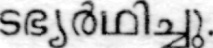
ടഭ്യര്‍ഥിച്ചു.
